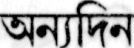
অন্যদিন
